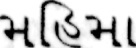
મહિમા
